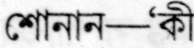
শোনান–‘কী
